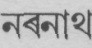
নৰনাথ
